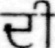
ਦੀ
